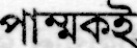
পাম্মকই
